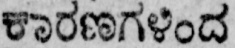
ಕಾರಣಗಳಿಂದ
